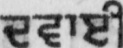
ਦਵਾਈ
